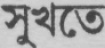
সুখতে
